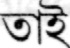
তাই
